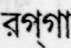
রগ্গা
